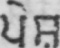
ਪੇਸ਼
